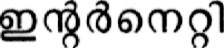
ഇന്റര്‍നെറ്റി
